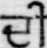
ਦੀ
